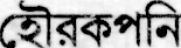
হৌকপনি
